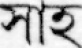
সাহ
